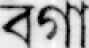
বগা
